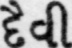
દૈવી
